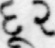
દૂર
